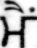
ਮੈਂ
